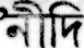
’নীদি
